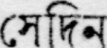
সেদিন
